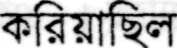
করিয়াছিল
